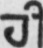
ਹੀ
